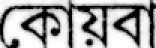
কোয়বা
